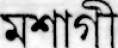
মশাগী
